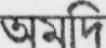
অমদি
